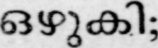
ഒഴുകി;
